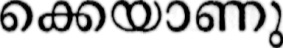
ക്കെയാണു
